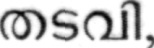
തടവി,
